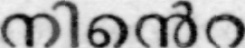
നിന്റെ
